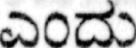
ಎಂದು
